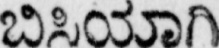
ಬಿಸಿಯಾಗಿ
